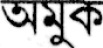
অমুক
